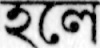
হলে
